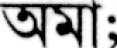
অমা;
